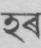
হৰ
